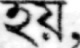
হয়,
